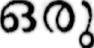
ഒരു
